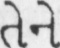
તેને
